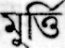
মুর্ত্তি
